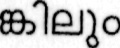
ങ്കിലും
